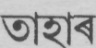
তাহাৰ
